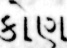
કોણ
